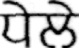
ਧੇਲੇ
